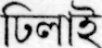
ঢিলাই
